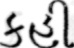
કહી
